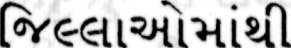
જિલ્લાઓમાંથી
